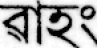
ৱাহং
